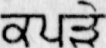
ਕਪੜੇ
